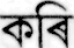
কৰি
